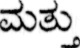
ಮತ್ತು
